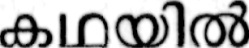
കഥയില്‍
